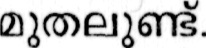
മുതലുണ്ട്.
